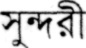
সুন্দরী
